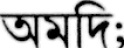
অমদি;
